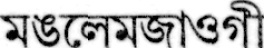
মঙলেমজাওগী
